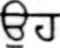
ਉਹ
